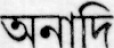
অনাদি
